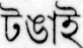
টঙাই
